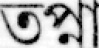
তপ্না
